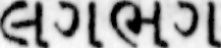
લગભગ
